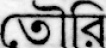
তৌরি
